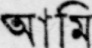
আমি
